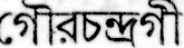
গৌরচন্দ্রগী
